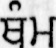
ਥੰਮ
